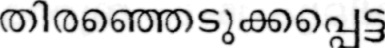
തിരഞ്ഞെടുക്കപ്പെട്ട
